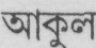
আকুল
